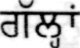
ਗੱਲ੍ਹਾਂ
